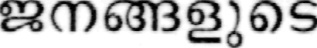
ജനങ്ങളുടെ
